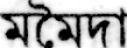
মমৈদা
